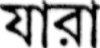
যারা
